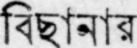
বিছানার
